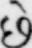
છે
